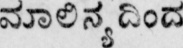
ಮಾಲಿನ್ಯದಿಂದ
